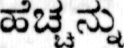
ಹೆಚ್ಚನ್ನು
